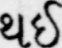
થઈ
